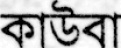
কাউবা
